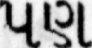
પણ
